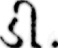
ડી.
